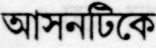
আসনটিকে
